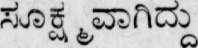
ಸೂಕ್ಷ್ಮವಾಗಿದ್ದು
